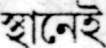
স্থানেই
